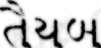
તૈયબ
